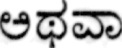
ಅಥವಾ
